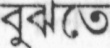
বুঝতে
